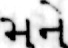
મને
